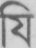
যি
